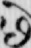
છે
